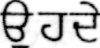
ਉਹਦੇ
